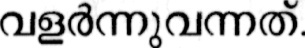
വളര്‍ന്നുവന്നത്.
